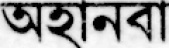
অহানবা
